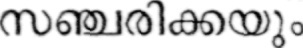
സഞ്ചരിക്കയും
